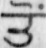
ਤੋਂ
